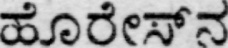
ಹೊರೇಸ್‌ನ
